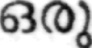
ഒരു
